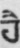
ਹੈ
